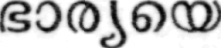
ഭാര്യയെ
